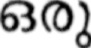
ഒരു
